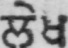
ਲੇਖ
